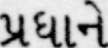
પ્રધાને
